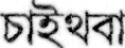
চাইথবা
